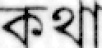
কথা
